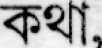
কথা,
